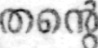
തന്റെ
